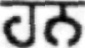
ਹਨ
